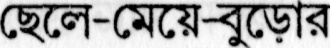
ছেলে-মেয়ে-বুড়োর
